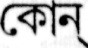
কোন্
